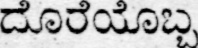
ದೊರೆಯೊಬ್ಬ
